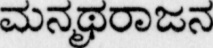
ಮನ್ಮಥರಾಜನ
